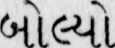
બોલ્યો
